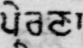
ਪ੍ਰੇਰਣਾ
